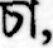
চা,
